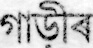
গাড়ীৰ
